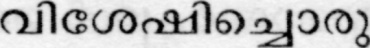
വിശേഷിച്ചൊരു
